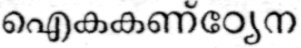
ഐകകണ്ഠ്യേന
